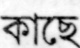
কাছে
